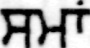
ਸਮਾਂ
